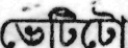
ভেটিটো
